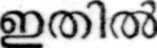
ഇതില്‍
